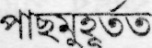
পাছমুহূর্তত
